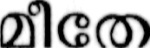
മീതേ
